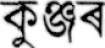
কুঞ্জৰ
